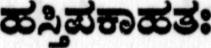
ಹಸ್ತಿಪಕಾಹತಃ
